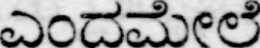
ಎಂದಮೇಲೆ
